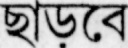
ছাড়বে
